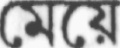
মেয়ে
